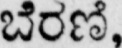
ಬೆರಣಿ,
